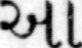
આ
